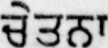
ਚੇਤਨਾ
